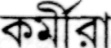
কর্মীরা
